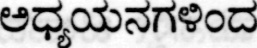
ಅಧ್ಯಯನಗಳಿಂದ
